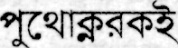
পুথোক্নরকই
